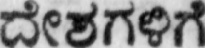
ದೇಶಗಳಿಗೆ
